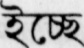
ইচ্ছে
